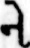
ને
